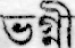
ভগ্নী
